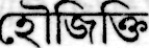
হৌজিক্তি
